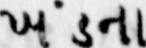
ખંડના
